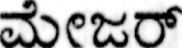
ಮೇಜರ್
